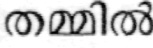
തമ്മില്‍
